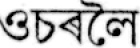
ওচৰলৈ
